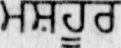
ਮਸ਼ਹੂਰ
